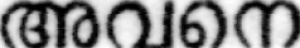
അവനെ
